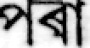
পৰা
